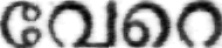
വേറെ
